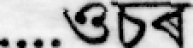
...ওচৰ
